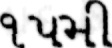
૧૫મી
